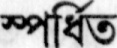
স্পর্ধিত
